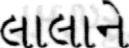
લાલાને
